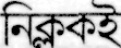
নিক্লকই
